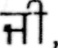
ਜੀ,
